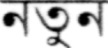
নতুন
